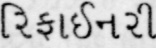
રિફાઈનરી
